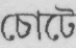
চোটে
